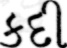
કદી
